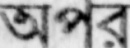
অপর
